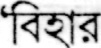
‘বিহার
